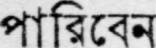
পারিবেন
